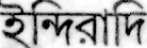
ইন্দিরাদি
